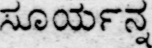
ಸೂರ್ಯನ್ನ
